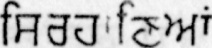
ਸਿਰਹਾਣਿਆਂ
